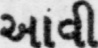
આવી
